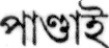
পাণ্ডাই
